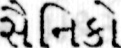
સૈનિકો
